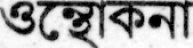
ওন্থোকনা
